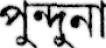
পুন্দুনা
